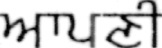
ਆਪਣੀ
